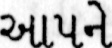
આપને
